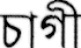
চাগী
